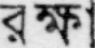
রক্ষা
